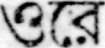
ওরে
